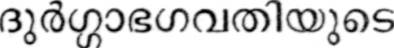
ദുര്‍ഗ്ഗാഭഗവതിയുടെ
